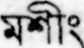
মশীং
